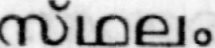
സ്ഥലം
